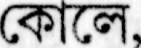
কোলে,
